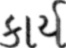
કાર્ય
